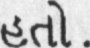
હતો.
